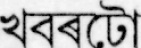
খবৰটো
